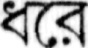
ধরে
